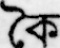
কৈ
